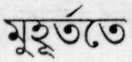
মুহূর্ততে
